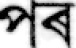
পৰ
